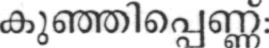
കുഞ്ഞിപ്പെണ്ണ്:
